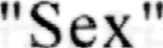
"Sex"
